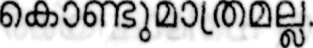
കൊണ്ടുമാത്രമല്ല.
